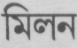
মিলন
